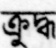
ক্রুদ্ধ
